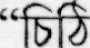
"চিঠি
